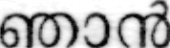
ഞാന്‍
